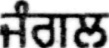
ਜੰਗਲ
